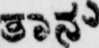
ತಾನು
